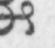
ಈ
